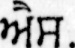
ਐਸ.
